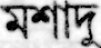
মশাদু
